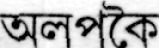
অলপকৈ
